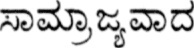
ಸಾಮ್ರಾಜ್ಯವಾದ
